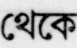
থেকে
